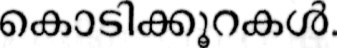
കൊടിക്കൂറകള്‍.
